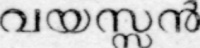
വയസ്സന്‍
